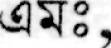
এমঃ,
